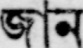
জান
